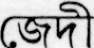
জেদী
